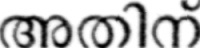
അതിന്
